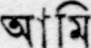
আমি
